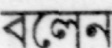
বলেন
